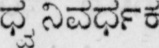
ಧ್ವನಿವರ್ಧಕ
